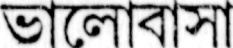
ভালোবাসা
